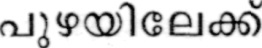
പുഴയിലേക്ക്
